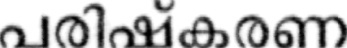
പരിഷ്കരണ
